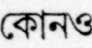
কোনও
